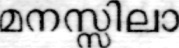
മനസ്സിലാ
